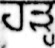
ਹੜ੍ਹ
